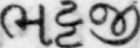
ભટ્ટજી
